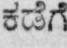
ಕಡೆಗೆ
